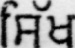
ਸਿੱਖ
